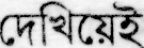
দেখিয়েই
